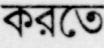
করতে
